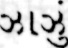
ઝાઝું
